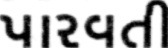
પારવતી
